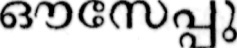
ഔസേപ്പു
